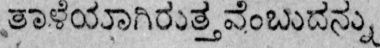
ತಾಳೆಯಾಗಿರುತ್ತವೆಂಬುದನ್ನು
